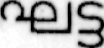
ഘട്ട
